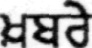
ਖ਼ਬਰੇ
